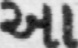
આ
